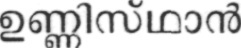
ഉണ്ണിസ്ഥാന്‍
